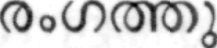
രംഗത്തു
